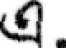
এ.
